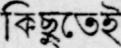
কিছুতেই
